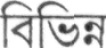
বিভিন্ন
